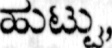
ಹುಟ್ಟು,
